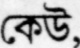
কেউ,
